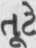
તૂટે
